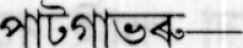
পাটগাভৰু-
